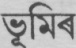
ভূমিৰ
